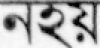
নহয়
